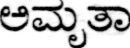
ಅಮೃತಾ
